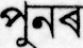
পুনৰ
